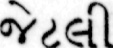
જેટલી
